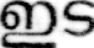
ഇട
